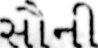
સૌની
